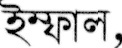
ইম্ফাল,
